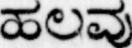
ಹಲವು
